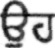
ਉਹ
